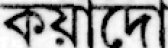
কয়াদো
